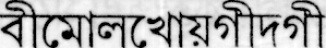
বীমোলখোয়গীদগী
